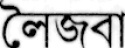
লৈজবা
